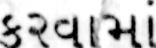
કરવામાં
